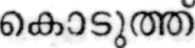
കൊടുത്ത്
